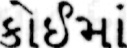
કોઈમાં
